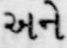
અને
